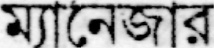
ম্যানেজার
